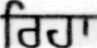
ਰਿਹਾ
